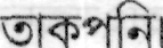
তাকপনি।
